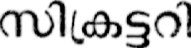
സിക്രട്ടറി
